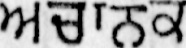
ਅਚਾਨਕ
